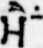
ਮੈਂ
